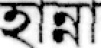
হান্না
